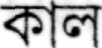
কাল
